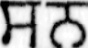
ਸਨ
